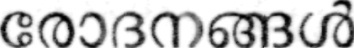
രോദനങ്ങള്‍
